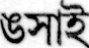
ঙসাই
